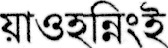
য়াওহন্নিংই
